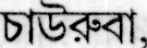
চাউরুবা,
